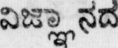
ವಿಜ್ಞಾನದ
